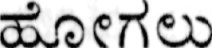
ಹೋಗಲು
